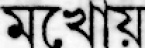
মখোয়
